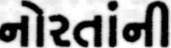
નોરતાંની
